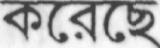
করেছে
